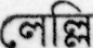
লেল্লি
